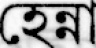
হেন্না
